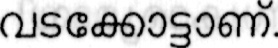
വടക്കോട്ടാണ്.
